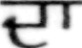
ਦਾ
